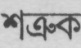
শত্রুক
